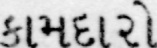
કામદારો
